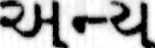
અન્ય
